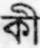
কী
